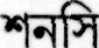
শনসি
